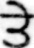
ਤੇ
